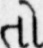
તો
